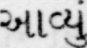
આવ્યું
